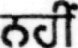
ਨਹੀਂ
